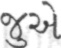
જુએ
